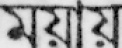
ময়ায়
